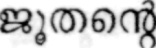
ജൂതന്റെ
